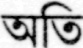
অতি
